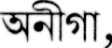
অনীগা,
